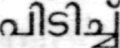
പിടിച്ച്
